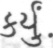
કર્યું.
